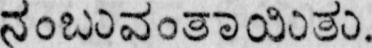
ನಂಬುವಂತಾಯಿತು.
